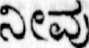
ನೀವು
